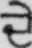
ਦੇ
